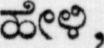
ಹೇಳಿ,
